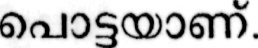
പൊട്ടയാണ്.
